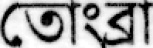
তোংব্রা
